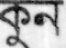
কুন
